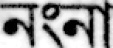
নংনা
